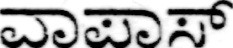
ವಾಪಾಸ್
